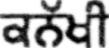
ਕਨੱਖੀ
